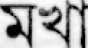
মখা
